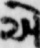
એ
